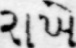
રાખે
